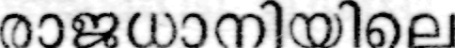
രാജധാനിയിലെ
